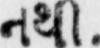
નથી.
